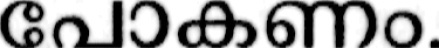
പോകണം.
